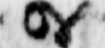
જ
